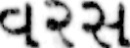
વરસ
